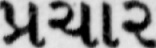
પ્રચાર
